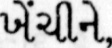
ખેંચીને,
